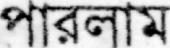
পারলাম
